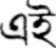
এই
